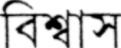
বিশ্বাস
